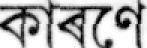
কাৰণে
